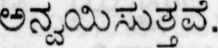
ಅನ್ವಯಿಸುತ್ತವೆ.
